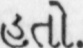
હતો.
